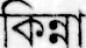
কিন্না
